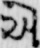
એ
